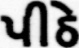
પીઠે
